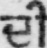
ਦੀ
